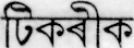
টিকৰীক
